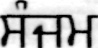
ਸੰਜਮ
